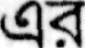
এর
